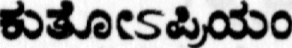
ಕುತೋsಪ್ರಿಯಂ
